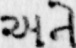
અને
